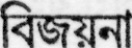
বিজয়না
